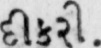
દીકરી.
